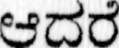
ಆದರೆ
